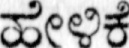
ಹೇಳಿಕೆ
